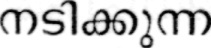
നടിക്കുന്ന
